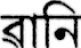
ৱানি
